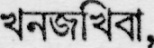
খনজখিবা,
